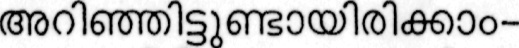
അറിഞ്ഞിട്ടുണ്ടായിരിക്കാം-.-
